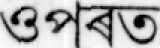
ওপৰত
